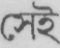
সেই
